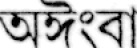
অঈংবা
